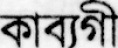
কাব্যগী
